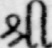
શ્રી
